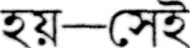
হয়–সেই
